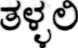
ತಳ್ಳಲಿ
